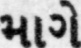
માગે
